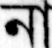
না
